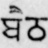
ਬੈਠ
